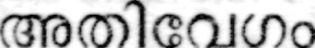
അതിവേഗം
